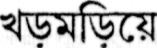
খড়মড়িয়ে
